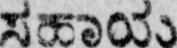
ಸಹಾಯ
